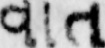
વાત
